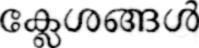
ക്ലേശങ്ങള്‍
